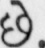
છે.
